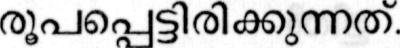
രൂപപ്പെട്ടിരിക്കുന്നത്.
